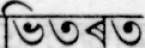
ভিতৰত
